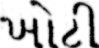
ખોટી
